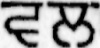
ਵਲ
